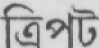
ত্ৰিপট
